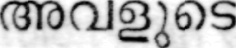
അവളുടെ
